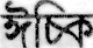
ঈচিক
